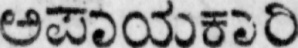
ಅಪಾಯಕಾರಿ
